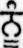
ਨੂੰ
